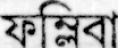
ফম্লিবা
